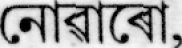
নোৱাৰো,
